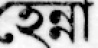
হেন্না
